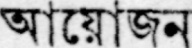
আয়োজন
